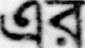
এর
